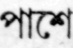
পাশে
